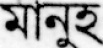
মানুহ
